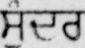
ਸੁੰਦਰ
